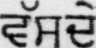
ਵੱਸਦੇ
